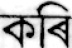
কৰি
